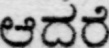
ಆದರೆ
